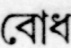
বোধ
